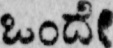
ಒಂದೇ
